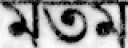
মতম
